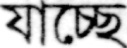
যাচ্ছে
